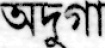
অদুগা
